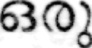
ഒരു
